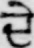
ਦੇ
